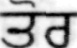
ਤੋਰ
